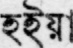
হইয়া
